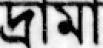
দ্রামা
